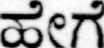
ಹೇಗೆ
